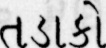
તડાકો
